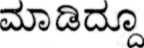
ಮಾಡಿದ್ದೂ
